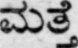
ಮತ್ತೆ
